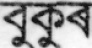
বুকুৰ
